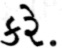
કરે.
